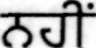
ਨਹੀਂ
